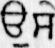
ਉਸੇ
